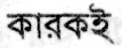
কারকই
